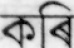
কৰি
